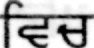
ਵਿਚ
